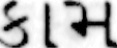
કામ
